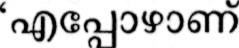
‘എപ്പോഴാണ്
